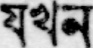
যখন
